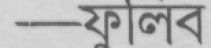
-ফুলিব
